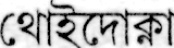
থোইদোক্না
